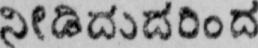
ನೀಡಿದುದರಿಂದ
